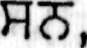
ਸਨ,
